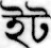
ইট
